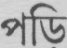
পড়ি
